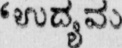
‘ಉದ್ಯಮ
